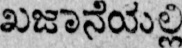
ಖಜಾನೆಯಲ್ಲಿ
